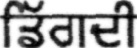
ਡਿੱਗਦੀ
